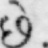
છે.
